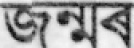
জন্মৰ
